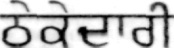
ਠੇਕੇਦਾਰੀ
